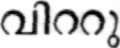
വിററു
